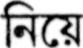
নিয়ে
